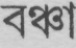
বঞ্চা
